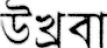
উখ্রবা
